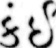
કંઈ
